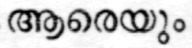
ആരെയും
